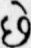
છે
